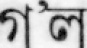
গ'ল
